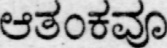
ಆತಂಕವೂ
